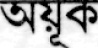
অয়ূক
